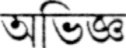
অভিজ্ঞ
